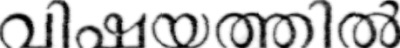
വിഷയത്തില്‍
